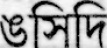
ঙসিদি
